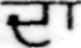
ਦਾ
